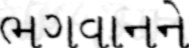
ભગવાનને
